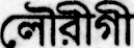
লৌরীগী
